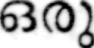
ഒരു
